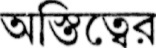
অস্তিত্বের
